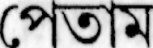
পেতাম
